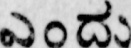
ಎಂದು
